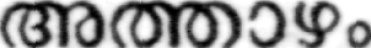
അത്താഴം
